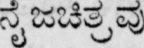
ನೈಜಚಿತ್ರವು
